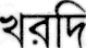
খরদি
